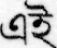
এই
